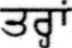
ਤਰ੍ਹਾਂ
